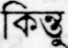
কিন্তু
